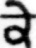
ਕੇ
